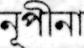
নূপীনা
